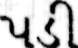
પડી
